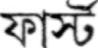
ফার্স্ট
